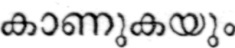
കാണുകയും
